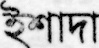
ইশাদা
